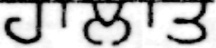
ਹਾਲਾਤ
